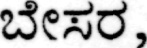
ಬೇಸರ,
